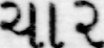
ચાર
